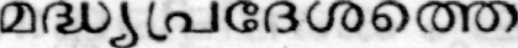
മദ്ധ്യപ്രദേശത്തെ
